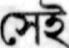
সেই
